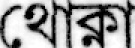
থোক্না
